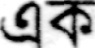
এক
